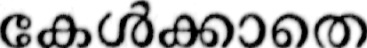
കേള്‍ക്കാതെ
